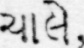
ચાલે,
